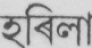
হৰিলা
